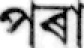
পৰা
